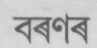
বৰণৰ
